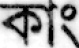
কাং
